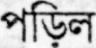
পড়িল
